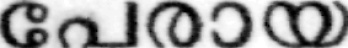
പേരായ
